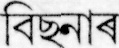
বিছনাৰ
